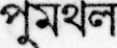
পুমথল
